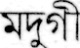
মদুগী
